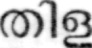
തിള
